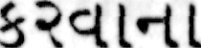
કરવાના
